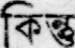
কিন্তু
